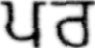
ਪਰ
